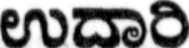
ಉದಾರಿ
